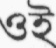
ওই
